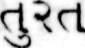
તુરત
